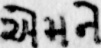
એમને
